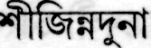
শীজিন্নদুনা
